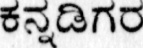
ಕನ್ನಡಿಗರ
